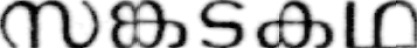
സങ്കടകഥ
